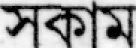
সকাম
